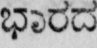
ಭಾರದ
